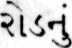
રોડનું
